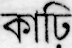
কাঢ়ি
